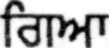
ਗਿਆ
